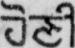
ਹੋਣੀ
